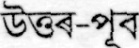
উত্তৰ-পূব
